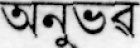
অনুভৱ
